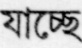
যাচ্ছে
